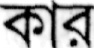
কার
